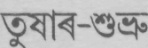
তুষাৰ-শুভ্ৰু
